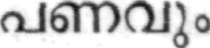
പണവും
